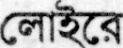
লোইরে
